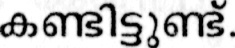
കണ്ടിട്ടുണ്ട്.
